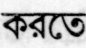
করতে
